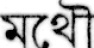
মথৌ
